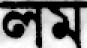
লম
